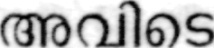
അവിടെ
